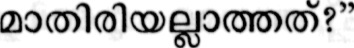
മാതിരിയല്ലാത്തത്?”
